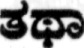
ತಥಾ
